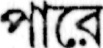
পারে
